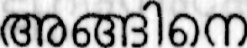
അങ്ങിനെ
